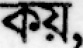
কয়,
